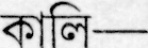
কালি-
